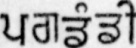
ਪਗਡੰਡੀ
